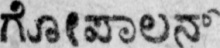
ಗೋಪಾಲನ್
